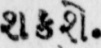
શકશે.
